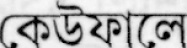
কেউফালে
